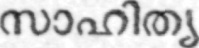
സാഹിത്യ
